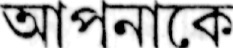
আপনাকে
